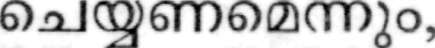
ചെയ്യണമെന്നും,
